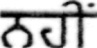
ਨਹੀਂ
